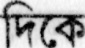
দিকে
